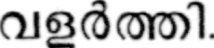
വളര്‍ത്തി.
